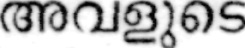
അവളുടെ
